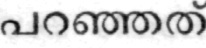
പറഞ്ഞത്
